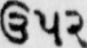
ઉપર
